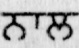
ਨਾਲ
